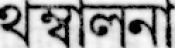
থম্বালনা
